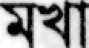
মখা
